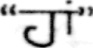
''ਹਾਂ''
